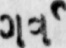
ગર્વ
